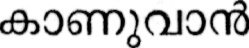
കാണുവാന്‍
